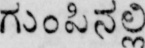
ಗುಂಪಿನಲ್ಲಿ
